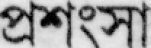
প্রশংসা
